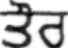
ਤੌਰ
